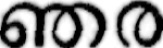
ഞര
